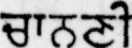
ਚਾਨਣੀ
